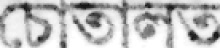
চোতালত
